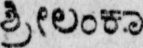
ಶ್ರೀಲಂಕಾ
